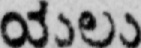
ಯಲು
